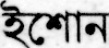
ইশোন
